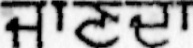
ਜਾਣਦਾ
